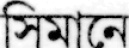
সিমানে
